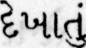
દેખાતું
